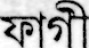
ফাগী
